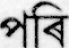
পৰি
